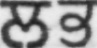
ਲਭ
